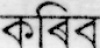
কৰিব
